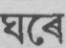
ঘৰে
